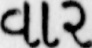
વાર
